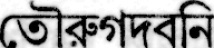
তৌরুগদবনি
